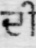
ਦੀ
